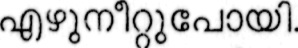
എഴുനീറ്റുപോയി.
